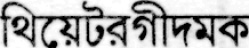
থিয়েটরগীদমক
